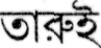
তারুই
